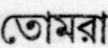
তোমরা
